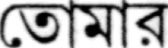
তোমার
